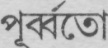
পূৰ্ব্বতো
